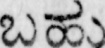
ಬಹು
